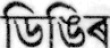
ডিঙিৰ
